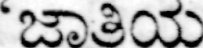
'ಜಾತಿಯ
